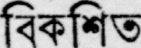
বিকশিত
